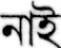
নাই
